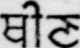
ਥੀਣ
